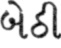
બેઠી
